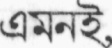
এমনই,
